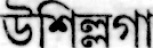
উইশিল্লগা
